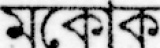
মকোক
